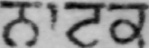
ਨਾਟਕ
